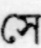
সে
